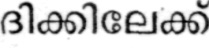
ദിക്കിലേക്ക്
